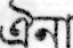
ঐনা
